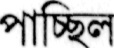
পাচ্ছিল
